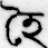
হৈ
